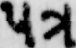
પત્ર
